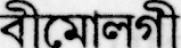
বীমোলগী
